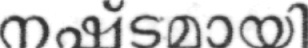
നഷ്ടമായി
